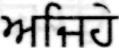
ਅਜਿਹੇ
